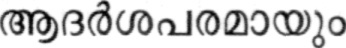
ആദര്‍ശപരമായും
